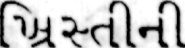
ખ્રિસ્તીની
